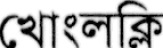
খোংলক্লি
